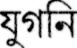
যুগনি
